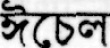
ঈচেল
